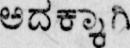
ಅದಕ್ಕಾಗಿ
